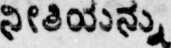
ನೀತಿಯನ್ನು
